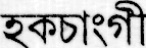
হকচাংগী
